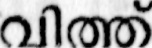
വിത്ത്
